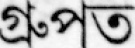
গ্রুপত
